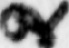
જ
